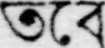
তবে
